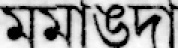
মমাঙদা
